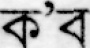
ক'ব
